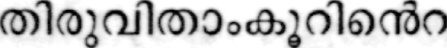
തിരുവിതാംകൂറിന്റെ
